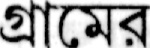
গ্রামের
